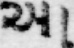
આ
